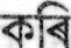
কৰি
